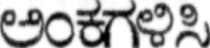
ಅಂಕಗಳಿಸಿ
